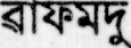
ৱাফমদু
